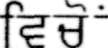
ਵਿਚੋਂ
